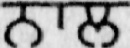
ਨਾਲ
